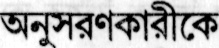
অনুসরণকারীকে
